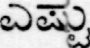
ಎಷ್ಟು
